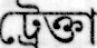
ট্রক্তা
